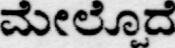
ಮೇಲ್ಪೊದೆ
